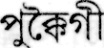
পুক্কৈগী
